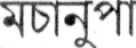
মচানুপা
